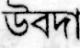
উবদা
